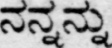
ನನ್ನನ್ನು
